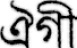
ঐগী
